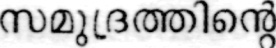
സമുദ്രത്തിന്റെ
